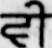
ਵੀ
